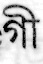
গী
